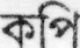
কপি
